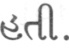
હતી.
